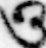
ও
